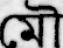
মৌ
